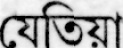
যেতিয়া
